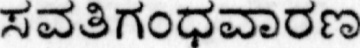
ಸವತಿಗಂಧವಾರಣ
